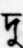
দু
